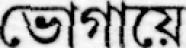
ভোগায়ে
